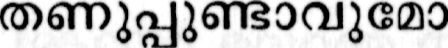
തണുപ്പുണ്ടാവുമോ
